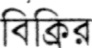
বিক্রির
